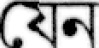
যেন
